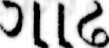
ગાઢ
